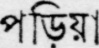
পড়িয়া
